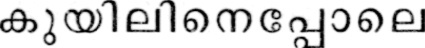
കുയിലിനെപ്പോലെ
